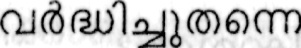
വര്‍ദ്ധിച്ചുതന്നെ
